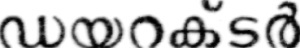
ഡയറക്ടര്‍
